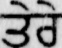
ਤੇਰੇ
